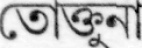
তোক্তুনা
